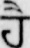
ਹੈ
